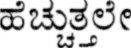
ಹೆಚ್ಚುತ್ತಲೇ
